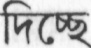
দিচ্ছে
